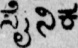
ಸೈನಿಕ
